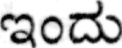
ಇಂದು
